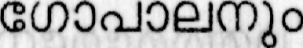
ഗോപാലനും
